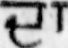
ਦਾ
